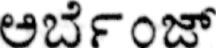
ಅರ್ಬೆಂಜ್
